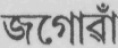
জগোৱাঁ
